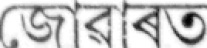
জোৱাৰত
